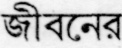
জীবনের
